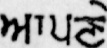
ਆਪਣੇ
